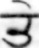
ਤੇ
